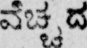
ವೆಚ್ಚದ
